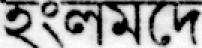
হংলমদে
